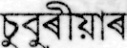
চুবুৰীয়াৰ
